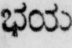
ಭಯ
